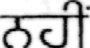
ਨਹੀਂ
